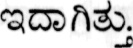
ಇದಾಗಿತ್ತು.
